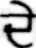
ਦੇ
